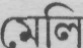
মেলি
